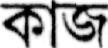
কাজ
